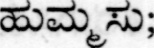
ಹುಮ್ಮಸು;
